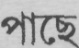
পাছে
